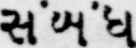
સંબંધ
